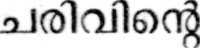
ചരിവിന്റെ
